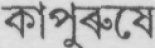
কাপুৰুষে
